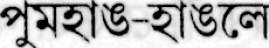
পুমহাঙ-হাঙলে
